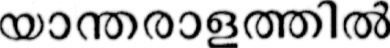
യാന്തരാളത്തില്‍
